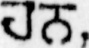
ਹਨ,
